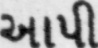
આપી
